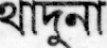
থাদুনা
